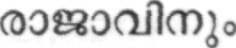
രാജാവിനും
